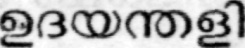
ഉദയന്തളി
